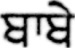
ਬਾਬੇ
